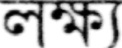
লক্ষ্য
